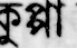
কুপ্পা
